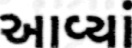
આવ્યાં
